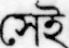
সেই
